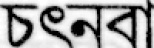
চৎনবা
